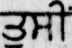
ਤੁਸੀਂ
